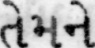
તેમને
